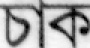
চাক
